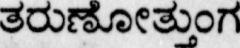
ತರುಣೋತ್ತುಂಗ
